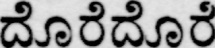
ದೊರೆದೊರೆ
